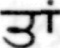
ਤਾਂ
